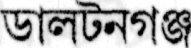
ডালটনগঞ্জ
